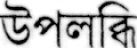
উপলব্ধি
